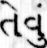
તેવું
